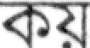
কয়
